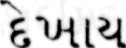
દેખાય
